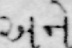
અને
